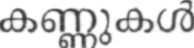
കണ്ണുകള്‍
